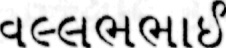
વલ્લભભાઈ
